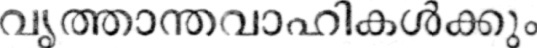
വൃത്താന്തവാഹികള്‍ക്കും
